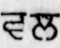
ਵਲ
